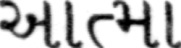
આત્મા
